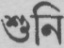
শুনি
